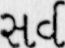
સર્વ
